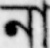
না
